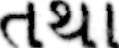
તથા
